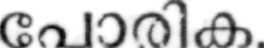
പോരിക.
